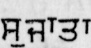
ਸੁਜਾਤਾ
